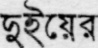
দুইয়ের
